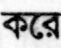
করে
